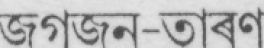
জগজন-তাৰণ
